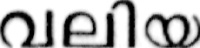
വലിയ
